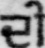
ਦੀ
